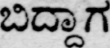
ಬಿದ್ದಾಗ
